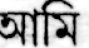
আমি
